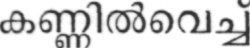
കണ്ണില്‍വെച്ച്
